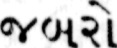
જબરો
